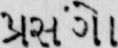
પ્રસંગો
